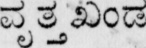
ವೃತ್ತಖಂಡ
